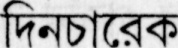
দিনচারেক
